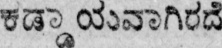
ಕಡ್ಡಾಯವಾಗಿರದೆ
